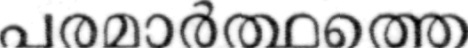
പരമാര്‍ത്ഥത്തെ
